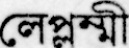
লেপ্লম্মী
